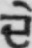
ਦੇ
